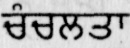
ਚੰਚਲਤਾ
